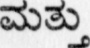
ಮತ್ತು
